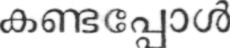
കണ്ടപ്പോള്‍
